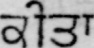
ਕੀਤਾ
